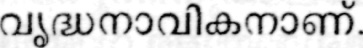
വൃദ്ധനാവികനാണ്.
